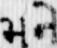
મને
